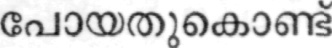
പോയതുകൊണ്ട്
